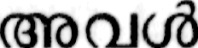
അവള്‍
